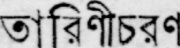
তারিণীচরণ
